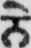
ਨੇ
